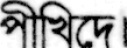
পীখিদে।
